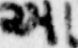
આ
